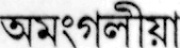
অমংগলীয়া
